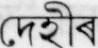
দেহীৰ
